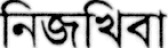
নিজখিবা
